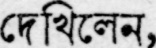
দেখিলেন,
